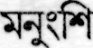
মনুংশি
